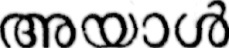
അയാള്‍
